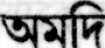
অমদি
